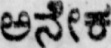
ಅನೇಕ
